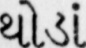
થોડાં
